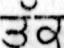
ਤੱਕ
